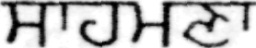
ਸਾਹਮਣਾ
